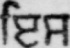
ਇਸ
